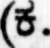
(ಕ.
